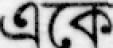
একে
